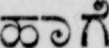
ಹಾಗೆ
